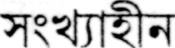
সংখ্যাহীন
